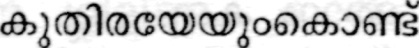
കുതിരയേയുംകൊണ്ട്
